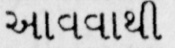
આવવાથી
